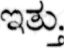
ಇತ್ತು.
